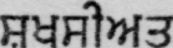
ਸ਼ਖਸੀਅਤ
